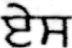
ਏਸ
